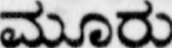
ಮೂರು
